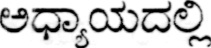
ಅಧ್ಯಾಯದಲ್ಲಿ
